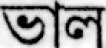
ভাল
